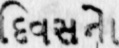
દિવસનો
